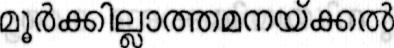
മൂര്‍ക്കില്ലാത്തമനയ്ക്കല്‍
